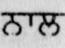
ਨਾਲ
